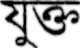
যুক্ত
